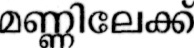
മണ്ണിലേക്ക്
